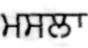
ਮਸਲਾ
